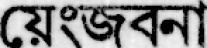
য়েংজবনা
